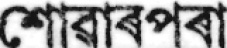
শোৱাৰপৰা
